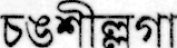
চঙশীল্লগা
